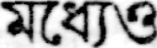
মধ্যেও
